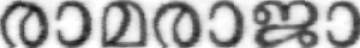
രാമരാജാ
